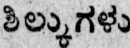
ಶಿಲ್ಕುಗಳು
